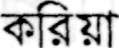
করিয়া
